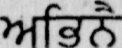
ਅਭਿਨੈ
